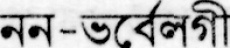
নন-ভর্বেলগী
